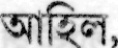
আহিল,
